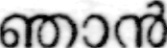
ഞാന്‍
